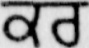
ਕਰ
